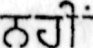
ਨਹੀਂ
